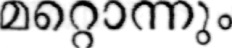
മറ്റൊന്നും
